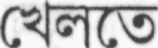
খেলতে
